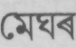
মেঘৰ
